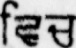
ਵਿਚ
